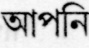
আপনি
